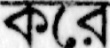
করে
